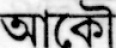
আকৌ
